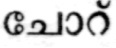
ചോറ്
